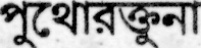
পুথোরক্তুনা
